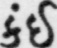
કંઈ
